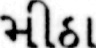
મીઠા
